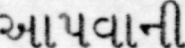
આપવાની
